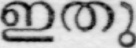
ഇതു
